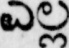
ಎಲ್ಲ
